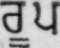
ਰੂਪ
